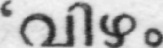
‘വിഴം
